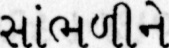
સાંભળીને
